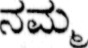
ನಮ್ಮ
